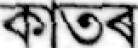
কাতৰ
